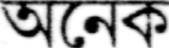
অনেক
